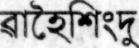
ৱাহৈশিংদু
